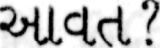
આવત?
